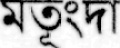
মতূংদা
